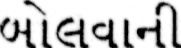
બોલવાની
